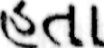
હતા
